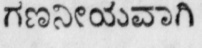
ಗಣನೀಯವಾಗಿ
